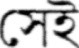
সেই
